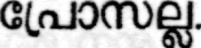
പ്രോസല്ല.
